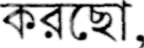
করছো,
